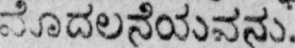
ಮೊದಲನೆಯವನು.
